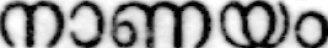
നാണയം
